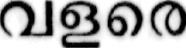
വളരെ
